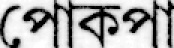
পোকপা
